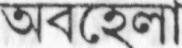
অবহেলা
